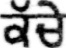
ਕੱਚੇ
